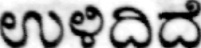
ಉಳಿದಿದೆ
